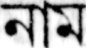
নাম
